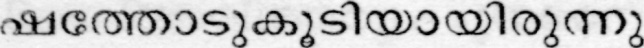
ഷത്തോടുകൂടിയായിരുന്നു
